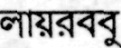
লায়রববু
